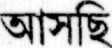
আসছি
